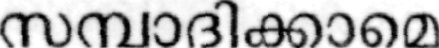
സമ്പാദിക്കാമെ
